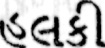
હલકી
